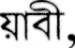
য়াবী,
